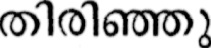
തിരിഞ്ഞു
